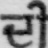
ਦੀ
